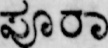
ಪೂರಾ
